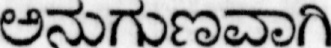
ಅನುಗುಣವಾಗಿ
